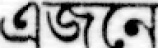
এজনে
